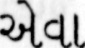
એવા
